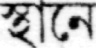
স্থানে
